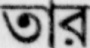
তার
